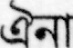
ঐনা
